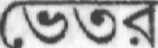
ভেতর
